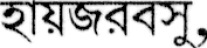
হায়জরবসু,
